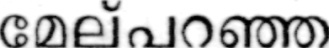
മേല്പറഞ്ഞ
